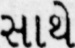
સાથે
